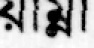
য়াম্না
